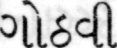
ગોઠવી
